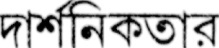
দার্শনিকতার
